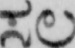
ಸಲ
